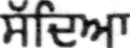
ਸੱਦਿਆ
